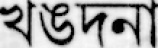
খঙদনা
